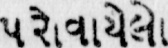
પરોવાયેલો
